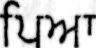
ਪਿਆ
